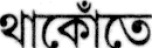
থাকোঁতে
